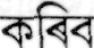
কৰিব
